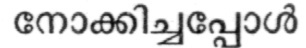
നോക്കിച്ചപ്പോള്‍
